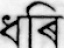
ধৰি
